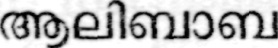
ആലിബാബ
